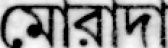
মোরাদা
